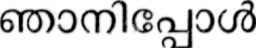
ഞാനിപ്പോള്‍
